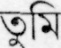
তুমি
